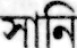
সানি
